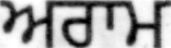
ਅਰਾਮ
